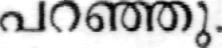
പറഞ്ഞു.
